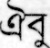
ঐবু
